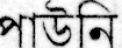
পাউনি
